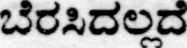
ಬೆರಸಿದಲ್ಲದೆ
